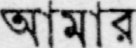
আমার
